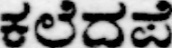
ಕಲೆದಪೆ
